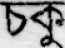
চকু
